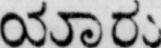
ಯಾರು
